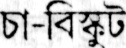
চা-বিস্কুট
